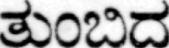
ತುಂಬಿದ
